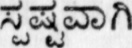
ಸ್ಪಷ್ಟವಾಗಿ
